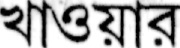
খাওয়ার
